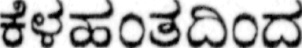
ಕೆಳಹಂತದಿಂದ
